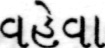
વહેવા
